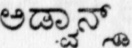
ಅಡ್ವಾನ್ಸ್ಡ್
